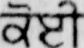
ਕੋਈ
